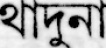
থাদুনা
